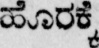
ಹೊರಕ್ಕೆ
